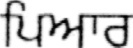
ਪਿਆਰ
